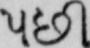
પછી
